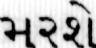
મરશે
